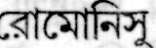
রোমোনিসু
